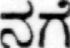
ನಗೆ
